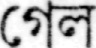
গেল
